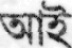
আই
